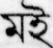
মই
